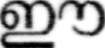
ഈ
